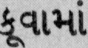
કૂવામાં
